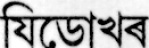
যিডোখৰ
